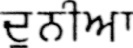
ਦੁਨੀਆ
